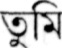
তুমি
